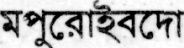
মপুরোইবদো
